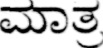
ಮಾತ್ರ
